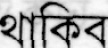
থাকিব
